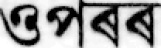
ওপৰৰ
